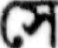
সে
